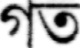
গত
